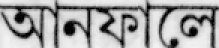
আনফালে
